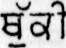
ਥੁੱਕੀ
